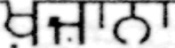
ਖ਼ਜਾਨਾ
